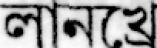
লানখ্রে
